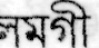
লমগী
